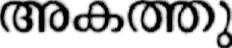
അകത്തു
